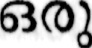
ഒരു
